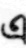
এ
